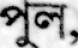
পুল,
